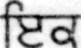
ਇਕ
